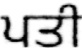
ਪਤੀ
